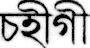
চহীগী
